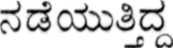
ನಡೆಯುತ್ತಿದ್ದ
